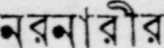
নরনারীর
